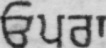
ਓਪਰਾ
